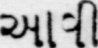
આવી
